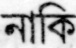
নাকি
